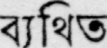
ব্যথিত
